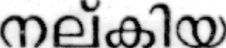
നല്കിയ
